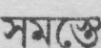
সমস্তে
